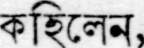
কহিলেন,
